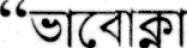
“ভাবোক্না
